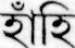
হাঁহি
